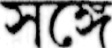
সঙ্গে
